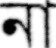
না
